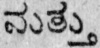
ಮತ್ತು
